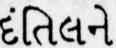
દંતિલને
